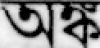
অঙ্ক
